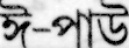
ঈ-পাউ
